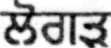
ਲੋਗੜ
